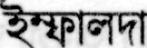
ইম্ফালদা
